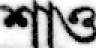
শাও
